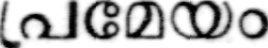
പ്രമേയം
